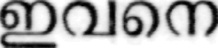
ഇവനെ
